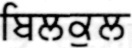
ਬਿਲਕੁਲ
